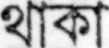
থাকা
